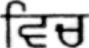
ਵਿਚ
